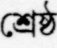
শ্রেষ্ঠ
